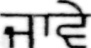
ਜਾਵੇ
